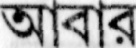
আবার
